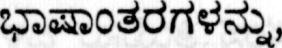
ಭಾಷಾಂತರಗಳನ್ನು,
